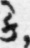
કે,
